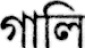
গালি
